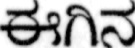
ಈಗಿನ
